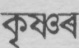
কৃষ্ণৰ
